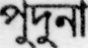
পুদুনা
